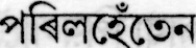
পৰিলহেঁতেন
